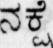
ನಕ್ಷೆ
